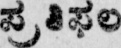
ಪ್ರತಿಫಲ
